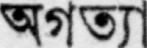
অগত্যা
